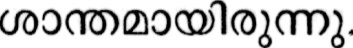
ശാന്തമായിരുന്നു.
